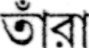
তাঁরা
